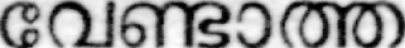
വേണ്ടാത്ത
